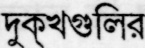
দুক্খগুলির
